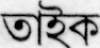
তাইক
